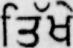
ਤਿੱਖੇ
